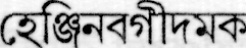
হেঞ্জিনবগীদমক
